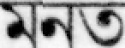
মনত
